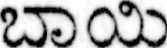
ಬಾಯಿ
